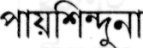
পায়শিন্দুনা
